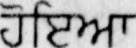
ਹੋਇਆ
